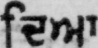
ਦਿਆ
